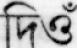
দিওঁ
